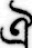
ঐ
